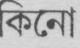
কিনো
